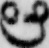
ಆ
